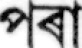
পৰা
